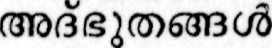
അദ്ഭുതങ്ങള്‍
